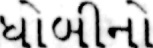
ધોબીનો
